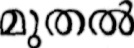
മുതല്‍
